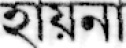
হায়না
